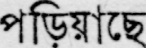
পড়িয়াছে
